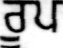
ਰੂਪ
